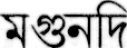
মগুনদি
